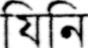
যিনি
